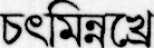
চৎমিন্নখ্রে
